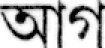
আগ
